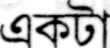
একটা
